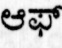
ಆಫ್
